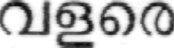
വളരെ
